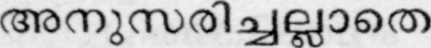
അനുസരിച്ചല്ലാതെ
